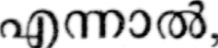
എന്നാല്‍,
